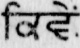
ਕਿਵੇਂ
